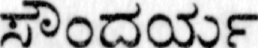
ಸೌಂದರ್ಯ
